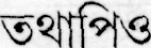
তথাপিও
